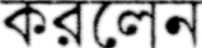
করলেন
